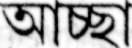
আচ্ছা
